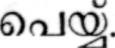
പെയ്യ്.
